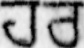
ਹਰ
